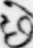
છે
